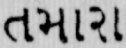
તમારા
